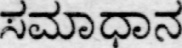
ಸಮಾಧಾನ
